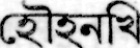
হৌহনখি
